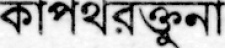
কাপথরক্তুনা
